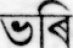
ভৰি
